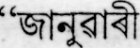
"জানুৱাৰী
